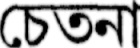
চেতনা
